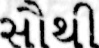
સૌથી
